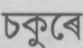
চকুৰে
